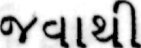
જવાથી
